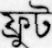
ফ্রুট
